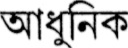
আধুনিক
